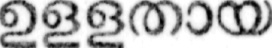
ഉളളതായ
